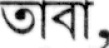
তাবা,
